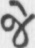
જે
